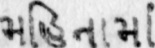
મહિનામાં
